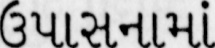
ઉપાસનામાં
